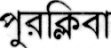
পুরক্লিবা
